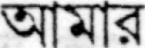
আমার
